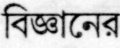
বিজ্ঞানের
